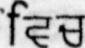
ਵਿਚ
